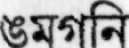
ঙমগনি
